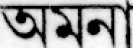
অমনা
